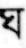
ঘ
